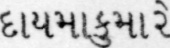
દાયમાકુમારે
